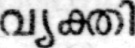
വ്യക്തി
